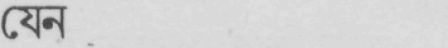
যেন
